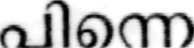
പിന്നെ
